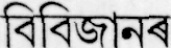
বিবিজানৰ
